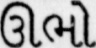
ઊભો
